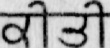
ਕੀਤੀ
